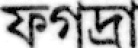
ফগদ্রা
